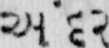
અંદર
